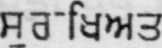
ਸੁਰਖਿਅਤ
